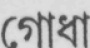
গোধা
